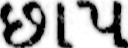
છાપ
